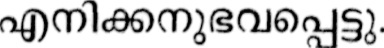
എനിക്കനുഭവപ്പെട്ടു.
